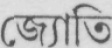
জ্যোতি
